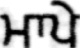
ਮਾਪੇ
